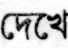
দেখে
